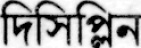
দিসিপ্লিন
